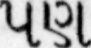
પણ
